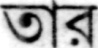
তার
